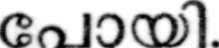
പോയി.
